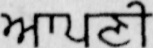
ਆਪਣੀ
